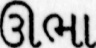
ઊભા
